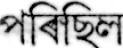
পৰিছিল
